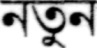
নতুন
